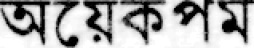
অয়েকপম
